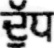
ਦੁੱਧ
